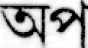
অপ
